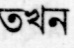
তখন
